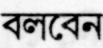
বলবেন
